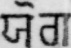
ਯੋਗ
